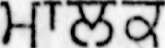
ਮਾਲਕ
